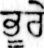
ਭੂਰੇ
